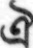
ঐ
